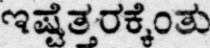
ಇಷ್ಟೆತ್ತರಕ್ಕೆಂತು
